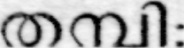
തമ്പി:
